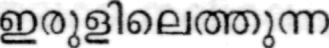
ഇരുളിലെത്തുന്ന
